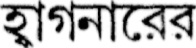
হ্বাগনারের
